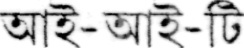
আই-আই-টি
